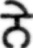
ਨੇ
